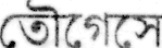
তৌগেসে
